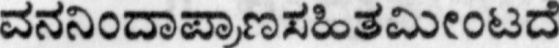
ವನನಿಂದಾಪ್ರಾಣಸಹಿತಮೀಂಟದೆ
